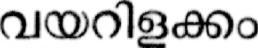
വയറിളക്കം
